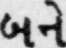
બને
